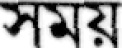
সময়
